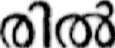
രില്‍
